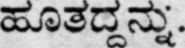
ಹೂತದ್ದನ್ನು.
